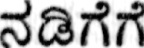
ನಡಿಗೆಗೆ
